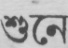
শুনে
